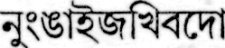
নুংঙাইজখিবদো
